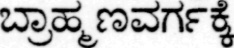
ಬ್ರಾಹ್ಮಣವರ್ಗಕ್ಕೆ
